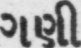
ગણી
